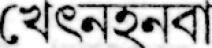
খেৎনহনবা
